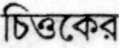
চিত্তকের
